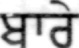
ਬਾਰੇ
